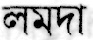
লমদা
